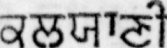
ਕਲਯਾਣੀ
